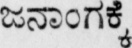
ಜನಾಂಗಕ್ಕೆ
